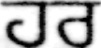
ਹਰ
